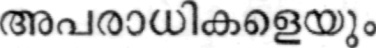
അപരാധികളെയും
